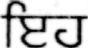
ਇਹ
